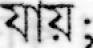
যায়;
